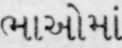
ભાઓમાં
